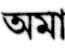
অমা
